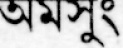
অমসুং
